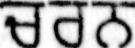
ਚਰਨ
